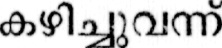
കഴിച്ചുവന്ന്
